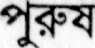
পুরুষ
